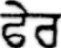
ਫੇਰ
